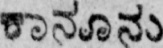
ಕಾನೂನು
